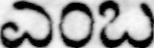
ಎಂಬ
